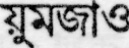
য়ুমজাও
